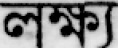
লক্ষ্য
